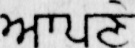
ਆਪਣੇ
